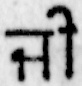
ਜੀ
